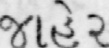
જાહેર
